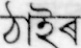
ঠাইৰ
